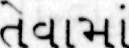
તેવામાં
